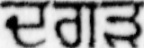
ਦਗੜ
